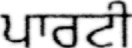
ਪਾਰਟੀ
